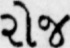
રોજ
